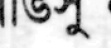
মাঙসু
